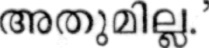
അതുമില്ല.’
